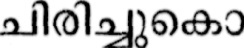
ചിരിച്ചുകൊ
